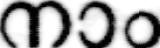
നാം
